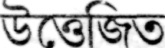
উত্তেজিত
